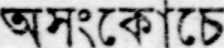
অসংকোচে
